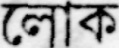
লোক
